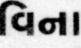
વિના
